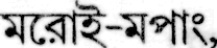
মরোই-মপাং,
